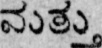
ಮತ್ತು
